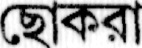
ছোকরা
